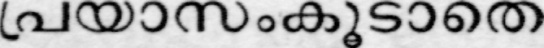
പ്രയാസംകൂടാതെ
